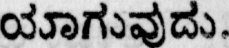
ಯಗುವುದು.
